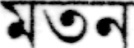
মতন
